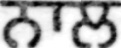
ਨਾਲ
